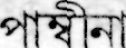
পাম্বীনা
